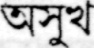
অসুখ
